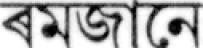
ৰমজানে
